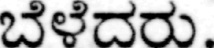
ಬೆಳೆದರು.
